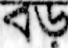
বড়
